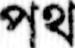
পথ
